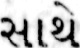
સાથે
